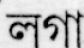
লগা
